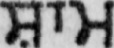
ਸ਼ਾਮ
